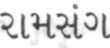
રામસંગ
